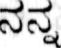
ನನ್ನ
